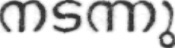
നടന്നു
